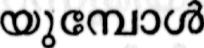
യുമ്പോള്‍
